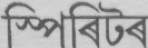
স্পিৰিটৰ
